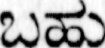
ಬಹು
